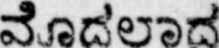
ಮೊದಲಾದ
